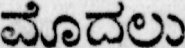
ಮೊದಲು
